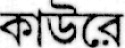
কাউরে
